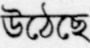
উঠেছে
